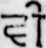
ਵੀ
